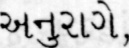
અનુરાગે,
